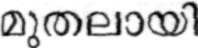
മുതലായി
